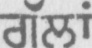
ਗੱਲਾਂ
